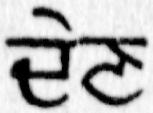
ਦੇਣ
